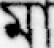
মা
